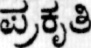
ಪ್ರಕೃತಿ
